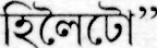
হিলৈটো"
